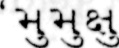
'મુમુક્ષુ
